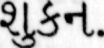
શુકન.
